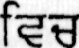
ਵਿਚ
